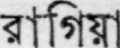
রাগিয়া
